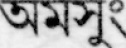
অমসুং
